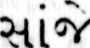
સાંજે
